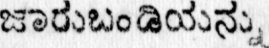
ಜಾರುಬಂಡಿಯನ್ನು
